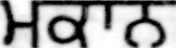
ਮਕਾਨ
